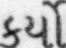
કર્યો
